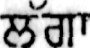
ਲੱਗਾ
